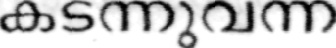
കടന്നുവന്ന
